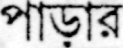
পাড়ার
